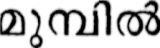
മുമ്പില്‍
